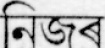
নিজৰ
